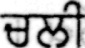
ਚਲੀ
